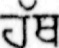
ਹੱਥ
